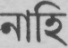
নাহি
